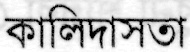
কালিদাসতা
